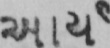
આર્ય
